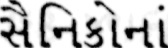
સૈનિકોનાં
